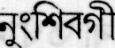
নুশিবগী
